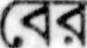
বের
